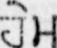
ਹੇਮ
